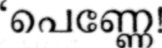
'പെണ്ണേ!
